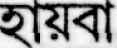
হায়বা
